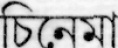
চিনেমা
